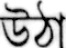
উঠা
